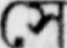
সে
